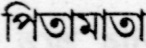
পিতামাতা
